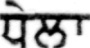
ਧੇਲਾ
